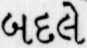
બદલે
